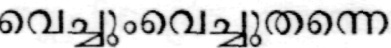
വെച്ചുംവെച്ചുതന്നെ
